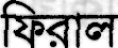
ফিরাল
